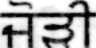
ਜੋੜੀ
